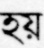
হয়
